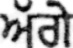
ਅੱਗੇ
